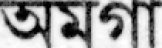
অমগা
